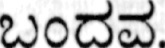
ಬಂದವ.
